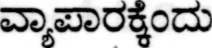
ವ್ಯಾಪಾರಕ್ಕೆಂದು
